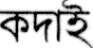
কদাই
